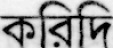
করিদি
